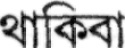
থাকিবা
